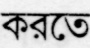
করতে
